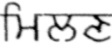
ਮਿਲਣ
